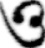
ও
